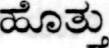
ಹೊತ್ತು
